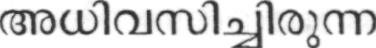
അധിവസിച്ചിരുന്ന
